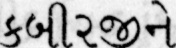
કબીરજીને
